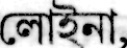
লোইনা,
